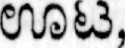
ಊಟ,
